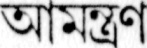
আমন্ত্রণ
